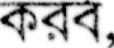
করব,
